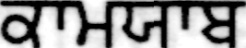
ਕਾਮਯਾਬ
